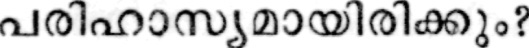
പരിഹാസ്യമായിരിക്കും?
